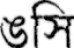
ঙসি
